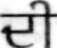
ਦੀ
